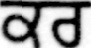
ਕਰ
